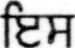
ਇਸ
